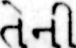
તેની
